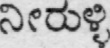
ನೀರುಳ್ಳಿ
